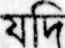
যদি
